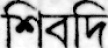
শিবদি
